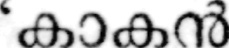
'കാകന്‍
